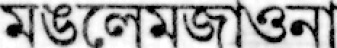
মঙলেমজাওনা
